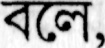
বলে,
